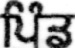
ਪਿੰਡ
